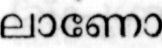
ലാണോ
